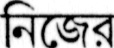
নিজের
